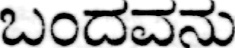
ಬಂದವನು
